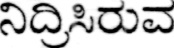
ನಿದ್ರಿಸಿರುವ
